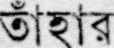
তাঁহার
